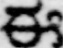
ಈ
